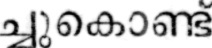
ച്ചുകൊണ്ട്
